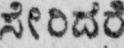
ಸೇರಿದರೆ
